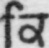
ਕਿ
